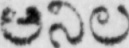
ಅನಿಲ
